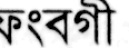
ফংবগী
